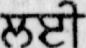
ਲਈ
